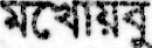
মখোয়বু
